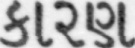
કારણ
